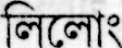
লিলোং
